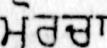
ਮੋਰਚਾ
